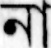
না
